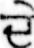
ਦੇ
